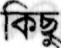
কিছু
